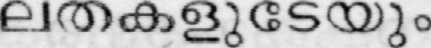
ലതകളുടേയും
